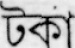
টকা
